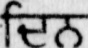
ਦਿਨ
